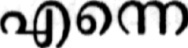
എന്നെ
